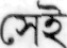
সেই
